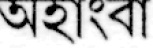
অহাংবা
